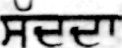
ਸੱਦਦਾ
